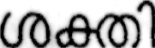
ശക്തി
